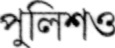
পুলিশও
